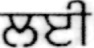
ਲਈ
